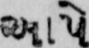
આપે
